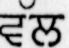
ਵੱਲ
